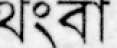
থংবা
